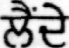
ਲੈਂਦੇ
